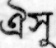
ঐসু
